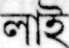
লাই
